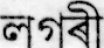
লগৰী
